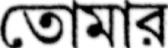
তোমার
